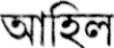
আহিল
